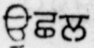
ਉਛਲ
